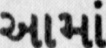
આમાં
